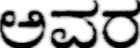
ಅವರ
